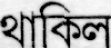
থাকিল
